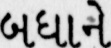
બધાને
